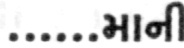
......માની
